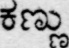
ಕಣ್ಣು
